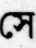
সে
